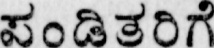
ಪಂಡಿತರಿಗೆ
